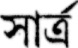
সার্ত্র
